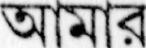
আমার
